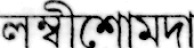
লম্বীশোমদা
